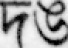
দঙ
